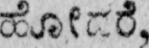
ಹೋದರೆ,
